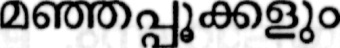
മഞ്ഞപ്പൂക്കളും
